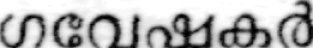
ഗവേഷകര്‍
